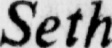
Seth
